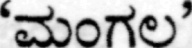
‘ಮಂಗಲ’
